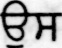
ਉਸ
